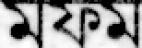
মফম
